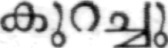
കുറച്ചു
